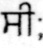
ਸੀ;
